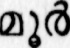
മൂര്‍
